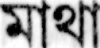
মাথা
